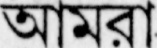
আমরা
